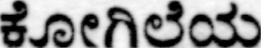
ಕೋಗಿಲೆಯ
